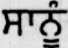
ਸਾਨੂੰ
